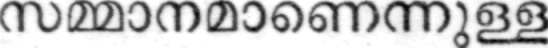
സമ്മാനമാണെന്നുള്ള
